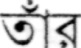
তাঁর
